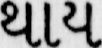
થાય
